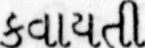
કવાયતી
